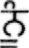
ਨੂੰ
